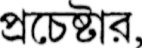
প্রচেষ্টার,
